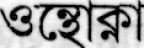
ওন্থোক্না
